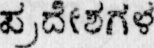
ಪ್ರದೇಶಗಳ
